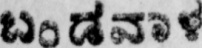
ಬಂಡವಾಳ
